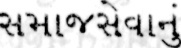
સમાજસેવાનું
